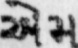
એમ
